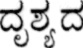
ದೃಶ್ಯದ
